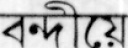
বন্দীয়ে
